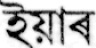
ইয়াৰ
